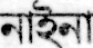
নাইনা
